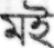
মই
